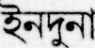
ইনদুনা
